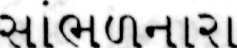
સાંભળનારા
